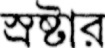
স্রষ্টার
